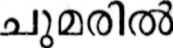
ചുമരില്‍
